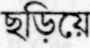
ছড়িয়ে
